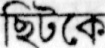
ছিটকে
